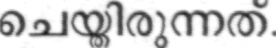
ചെയ്തിരുന്നത്.
